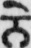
ਨੇ
